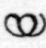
യ
